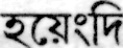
হয়েংদি
